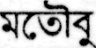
মতৌবু
